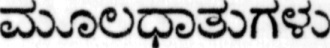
ಮೂಲಧಾತುಗಳು
